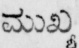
ಮುಖ್ಯ
